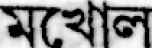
মখোল
